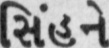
સિંહને
